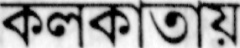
কলকাতায়
